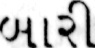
બારી
